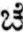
ಚೆ
